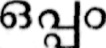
ഒപ്പം
